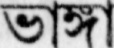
ভাঙ্গা
